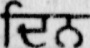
ਦਿਨ
